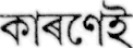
কাৰণেই
